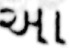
આ
